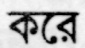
করে
